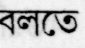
বলতে
